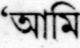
‘আমি
